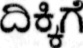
ದಿಕ್ಕಿಗೆ
